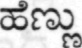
ಹೆಣ್ಣು
